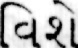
વિશે
